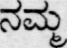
ನಮ್ಮ
